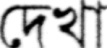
দেখা
